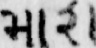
મારી
